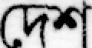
দেশ
